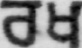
ਰਖ
